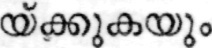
യ്ക്കുകയും
